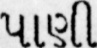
પાણી
